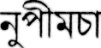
নুপীমচা
